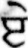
ਏ
